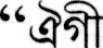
“ঐগী
